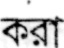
করা
